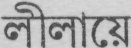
লীলায়ে
